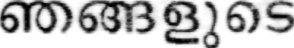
ഞങ്ങളുടെ
